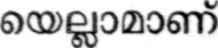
യെല്ലാമാണ്
